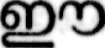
ഈ
